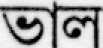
ভাল
